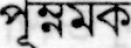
পূম্নমক
